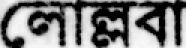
লোল্লবা
